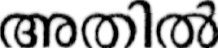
അതില്‍
